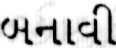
બનાવી
